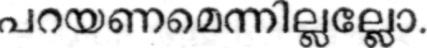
പറയണമെന്നില്ലല്ലോ.
